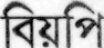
বিয়পি
